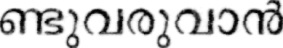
ണ്ടുവരുവാന്‍
